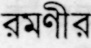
রমণীর
